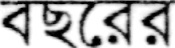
বছরের
